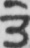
ਤੇ
